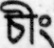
চীং
